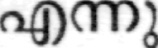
എന്നു
